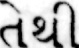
તેથી
